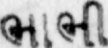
ભાભી
